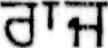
ਰਾਜ
